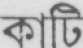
কাটি
